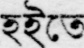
হইতে
